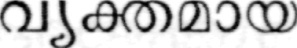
വ്യക്തമായ
